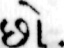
છો.
